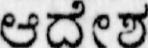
ಆದೇಶ
